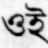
ওই
